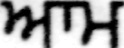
ਆਮ
